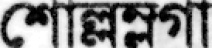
শোল্লম্লগা
